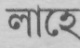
লাহে
